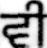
ਵੀ
